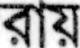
রায়
